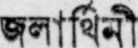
জলার্থিনী
